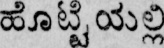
ಹೊಟ್ಟೆಯಲ್ಲಿ
